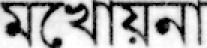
মখোয়না
